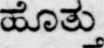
ಹೊತ್ತು
